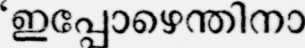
'ഇപ്പോഴെന്തിനാ
